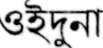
ওইদুনা
